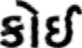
કોઈ
